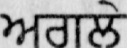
ਅਗਲੇ
